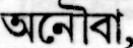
অনৌবা,
